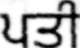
ਪਤੀ
